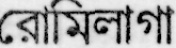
রোমিলাগা
